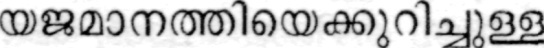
യജമാനത്തിയെക്കുറിച്ചുള്ള
